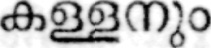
കള്ളനും
